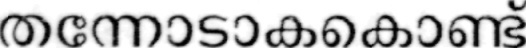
തന്നോടാകകൊണ്ട്
